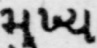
મુખ્ય
